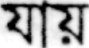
যায়
